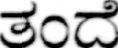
ತಂದೆ
